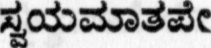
ಸ್ವಯಮಾತಪೇ
